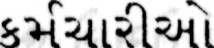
કર્મચારીઓ
